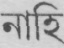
নাহি
